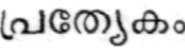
പ്രത്യേകം
